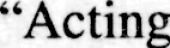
“Acting
